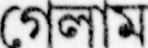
গেলাম
